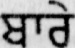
ਬਾਰੇ
